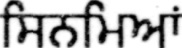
ਸਿਨਮਿਆਂ
